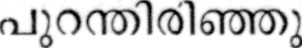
പുറന്തിരിഞ്ഞു
